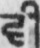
ਵੀ
